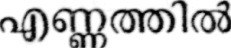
എണ്ണത്തില്‍
